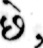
છે,
